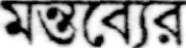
মন্তব্যের
